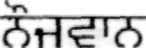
ਨੌਜਵਾਨ
